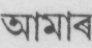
আমাৰ
